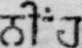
ਨੀਂਹ
